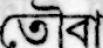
তৌবা
